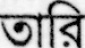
তারি
